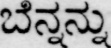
ಬೆನ್ನನ್ನು
